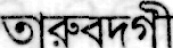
তারুবদগী
